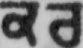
ਕਰ
